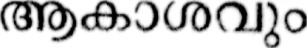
ആകാശവും
